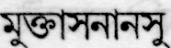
মুক্তাসনানসু
